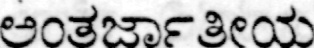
ಅಂತರ್ಜಾತೀಯ
